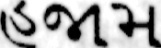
હજામ
